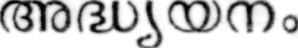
അദ്ധ്യയനം
